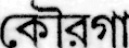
কৌরগা
